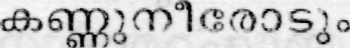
കണ്ണുനീരോടും
